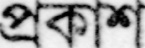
প্রকাশ
